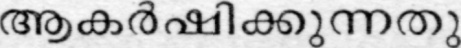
ആകര്‍ഷിക്കുന്നതു
